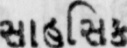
સાહસિક
